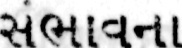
સંભાવના
